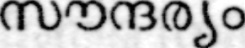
സൌന്ദര്യം
